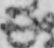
ಈ
